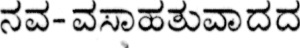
ನವ-ವಸಾಹತುವಾದದ
